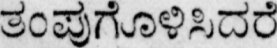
ತಂಪುಗೊಳಿಸಿದರೆ
